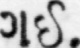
ગઈ.
